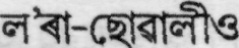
ল'ৰা-ছোৱালীও
